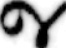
જ
